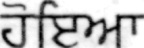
ਹੋਇਆ
